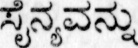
ಸೈನ್ಯವನ್ನು
